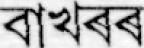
বাখৰৰ
